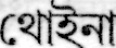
থোইনা
